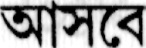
আসবে
